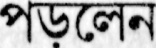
পড়লেন
